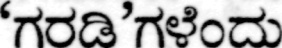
‘ಗರಡಿ’ಗಳೆಂದು
